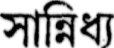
সান্নিধ্য
